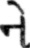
ને
